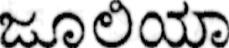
ಜೂಲಿಯಾ
